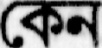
কেন
